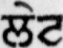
ਲੇਟ
